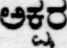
ಅಕ್ಷರ
